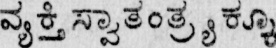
ವ್ಯಕ್ತಿಸ್ವಾತಂತ್ರ್ಯಕ್ಕೂ
